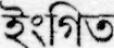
ইংগিত
